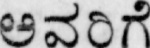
ಅವರಿಗೆ
